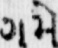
ગમે
